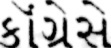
કૉંગ્રેસે
